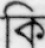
কি
